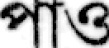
পাও
